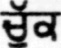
ਚੁੱਕ
